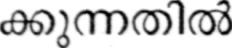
ക്കുന്നതില്‍
